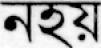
নহয়
